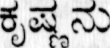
ಕೃಷ್ಣನು
